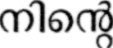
നിന്റെ
